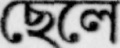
ছেলে
